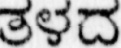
ತಳದ
